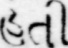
હતી
